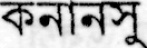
কনানসু
